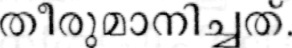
തീരുമാനിച്ചത്.
